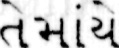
તેમાંયે
